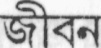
জীবন
